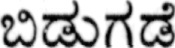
ಬಿಡುಗಡೆ
